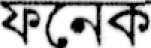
ফনেক
